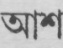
আশ
